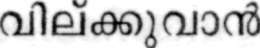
വില്ക്കുവാന്‍
